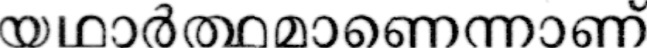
യഥാര്‍ത്ഥമാണെന്നാണ്
